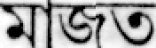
মাজত
